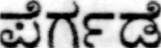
ಪೆರ್ಗಡೆ
